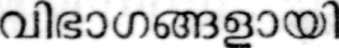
വിഭാഗങ്ങളായി
